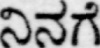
ನಿನಗೆ
